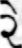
કે
